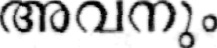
അവനും
